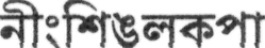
নীংশিঙলকপা
